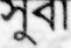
সুবা
